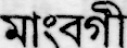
মাংবগী
